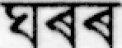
ঘৰৰ
